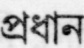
প্রধান
